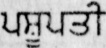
ਪਸ਼ੂਪਤੀ
